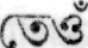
তেওঁ
